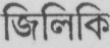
জিলিকি
